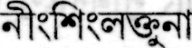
নীংশিংলক্তুনা
